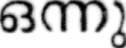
ഒന്നു
